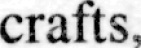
crafts,
